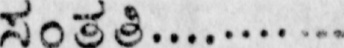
ಸಂತತಿ........
